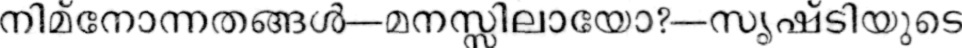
നിമ്നോന്നതങ്ങള്‍-മനസ്സിലായോ?-സൃഷ്ടിയുടെ
